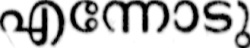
എന്നോടു
